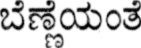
ಬೆಣ್ಣೆಯಂತೆ
